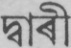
দ্বাৰী
